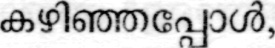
കഴിഞ്ഞപ്പോള്‍,
